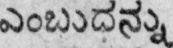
ಎಂಬುದನ್ನು
